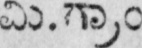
ಮಿ.ಗ್ರಾಂ
